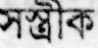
সস্ত্রীক
